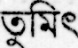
তুমিৎ
